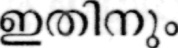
ഇതിനും
